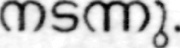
നടന്നു.
